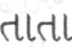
તાતા
